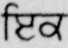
ਇਕ
